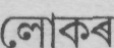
লোকৰ
